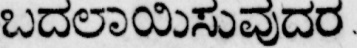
ಬದಲಾಯಿಸುವುದರ.
